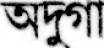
অদুগা
